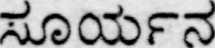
ಸೂರ್ಯನ
